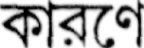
কারণে
